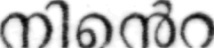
നിന്റെ
